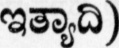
ಇತ್ಯಾದಿ)
